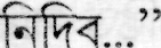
নিদিব..."
